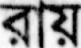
রায়
